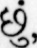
છું,
